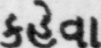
કહેવા
